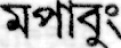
মপাবুং
